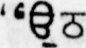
''ਉਠ
